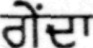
ਗੇਂਦਾ
